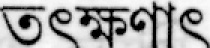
তৎক্ষণাৎ
